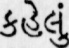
કહેલું
